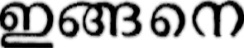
ഇങ്ങനെ
